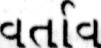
વર્તાવ
